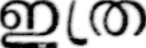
ഇത്ര
